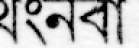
থংনবা
